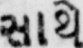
સાથે
